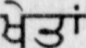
ਖੇਤਾਂ
